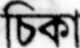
চিকা
